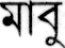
মাবু
